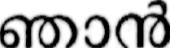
ഞാന്‍
